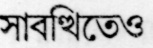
সাবত্থিতেও
